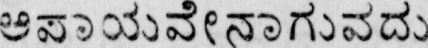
ಅಪಾಯವೇನಾಗುವದು
